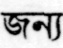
জন্য
